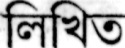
লিখিত
